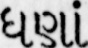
ધણાં
